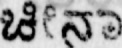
ಚೀನಾ
